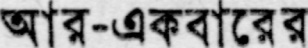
আর-একবারের
